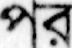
পর
